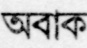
অবাক
